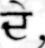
ਦੇ,
